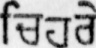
ਚਿਹਰੇ
